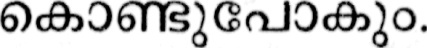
കൊണ്ടുപോകും.
